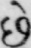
છે
